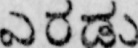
ಎರಡು
